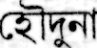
হৌদুনা
